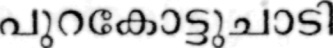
പുറകോട്ടുചാടി
